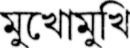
মুখোমুখি
